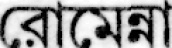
রোমেন্না
